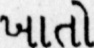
ખાતો
